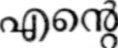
എന്റെ
